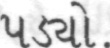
પડ્યો.
